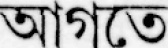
আগতে
